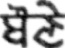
ਬੌਣੇ
